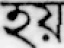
হয়
